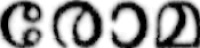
രോമ
